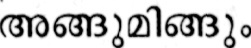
അങ്ങുമിങ്ങും
